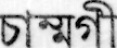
চাম্মগী
